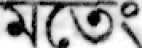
মতেং
